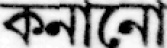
কনানো
